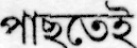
পাছতেই
